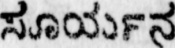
ಸೂರ್ಯನ
